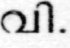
വി.
